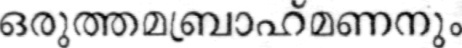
ഒരുത്തമബ്രാഹ്മണനും
